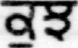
ਕੁਝ
